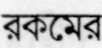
রকমের
